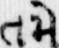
તમે
